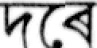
দৰে
